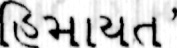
હિમાયત
